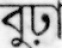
বুঢ়া
